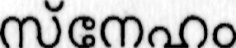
സ്നേഹം
